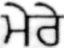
ਮੇਰੇ
